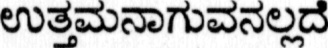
ಉತ್ತಮನಾಗುವನಲ್ಲದೆ
